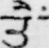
ਤੈਂ
